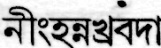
নীংহন্নখ্রবদা
